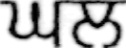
ਘਲ
